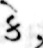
કે,
